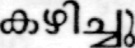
കഴിച്ചു
